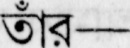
তাঁর-
